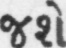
જશે
